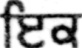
ਇਕ
